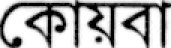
কোয়বা
